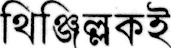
থিঞ্জিল্লকই
